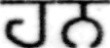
ਹਨ
